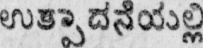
ಉತ್ಪಾದನೆಯಲ್ಲಿ
